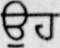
ਉਹ
